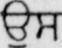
ਉਸ
